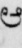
ಆ
